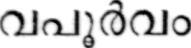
വപൂര്‍വം
